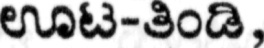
ಊಟ-ತಿಂಡಿ,
